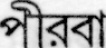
পীরবা
